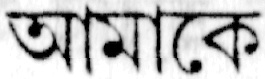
আমাকে
